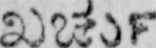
ಖರ್ಚು
